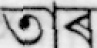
তাৰ
